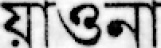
য়াওনা
